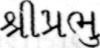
શ્રીપ્રભુ
